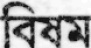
বিষম
